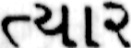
ત્યાર
